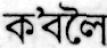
ক'বলৈ
